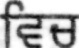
ਵਿਚ
